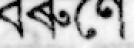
বৰুণে
